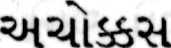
અચોક્કસ
